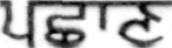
ਪਛਾਣ
